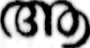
ആ
